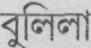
বুলিলা
